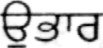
ਉਭਾਰ
